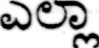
ಎಲ್ಲಾ
